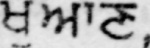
ਖੁਆਣ,
